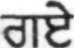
ਗਏ
